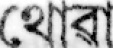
থোৱা
